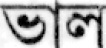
ভাল
